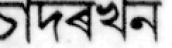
চাদৰখন
